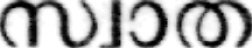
സ്വാത
